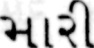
મારી
